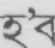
হ'ব
